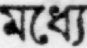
মধ্যে
